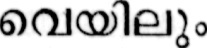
വെയിലും
